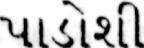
પાડોશી
